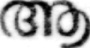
ആ
